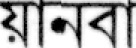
য়ানবা
